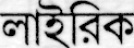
লাইরিক
